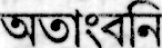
অতাংবনি
